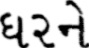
ધરને
